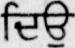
ਦਿਉ
